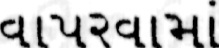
વાપરવામાં
